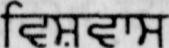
ਵਿਸ਼ਵਾਸ
